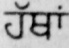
ਹੱਥਾਂ
